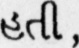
હતી,
